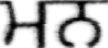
ਮਨ
